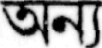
অন্য
